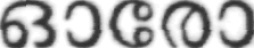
ഓരോ
